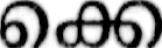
ക്കെ
